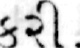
કરી.
